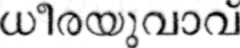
ധീരയുവാവ്
